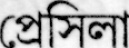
প্রেসিলা
